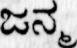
ಜನ್ಮ
